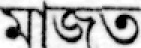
মাজত
